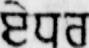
ਏਧਰ
